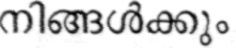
നിങ്ങള്‍ക്കും
